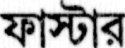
ফাস্টার
